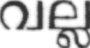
വല്ല
